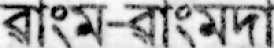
ৱাংম-ৱামদা
